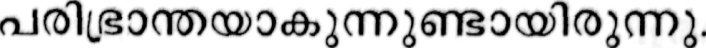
പരിഭ്രാന്തയാകുന്നുണ്ടായിരുന്നു.
